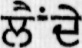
ਲੈਂਦੇ
